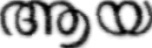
ആയ
